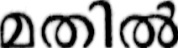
മതില്‍
